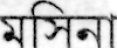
মসিনা
